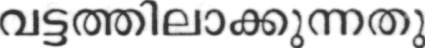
വട്ടത്തിലാക്കുന്നതു
